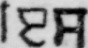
ਇਸ
